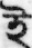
ই
